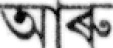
আৰু
